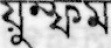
য়ুম্ফম
